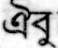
ঐবু
